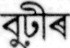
বুঢ়ীৰ
